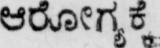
ಆರೋಗ್ಯಕ್ಕೆ
